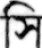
সি
